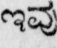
ಇವು
